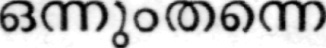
ഒന്നുംതന്നെ
